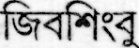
জিবশিংবু
